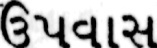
ઉપવાસ
